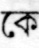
কে
